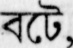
বটে,
